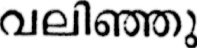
വലിഞ്ഞു
